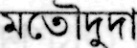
মতৌদুদা
